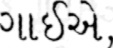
ગાઈએ,
